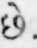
છે.
